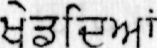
ਖੇਡਦਿਆਂ
